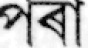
পৰা
